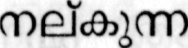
നല്കുന്ന
